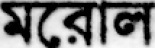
মরোল
